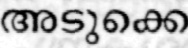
അടുക്കെ
